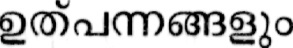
ഉത്പന്നങ്ങളും
